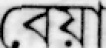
বেয়া
